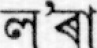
ল'ৰা
